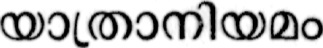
യാത്രാനിയമം
